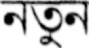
নতুন
